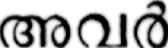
അവര്‍
